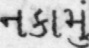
નકામું
